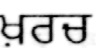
ਖ਼ਰਚ
